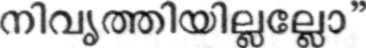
നിവൃത്തിയില്ലല്ലോ”
